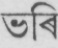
ভৰি
